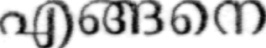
എങ്ങനെ
